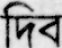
দিব
